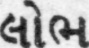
લોભ
